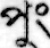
পুং
